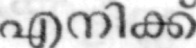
എനിക്ക്
